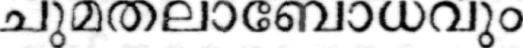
ചുമതലാബോധവും
